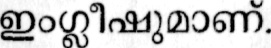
ഇംഗ്ലീഷുമാണ്.
